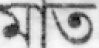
মাত
